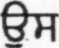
ਉਸ
